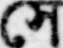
সে
